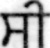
ਸੀ
